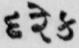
દરેક
